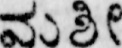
ಮಶೀ
